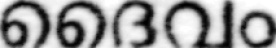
ദൈവം
